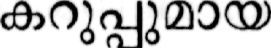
കറുപ്പുമായ
